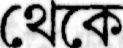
থেকে
